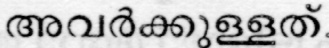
അവര്‍ക്കുള്ളത്.
